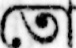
তো
